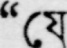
‘‘যে
